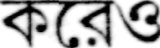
করেও
